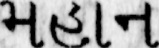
મહાન
